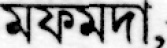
মফমদা,
